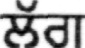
ਲੱਗ
